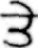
ਤੇ
